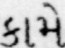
કામે
